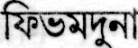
ফিভমদুনা
